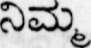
ನಿಮ್ಮ
